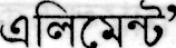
এলিমেন্ট’
